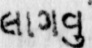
લાગવું
